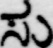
ಸು
